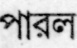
পারল
